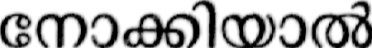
നോക്കിയാല്‍
